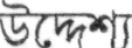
উদ্দেশ্য
